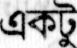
একটু
